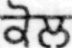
ਕੋਲ
